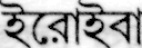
ইরোইবা
